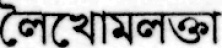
লৈখোমলক্তা
